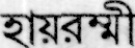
হায়রম্মী
